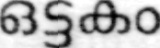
ഒട്ടകം
